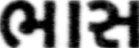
ભાસ
